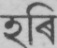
হৰি
